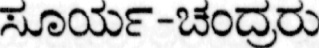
ಸೂರ್ಯ-ಚಂದ್ರರು
